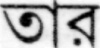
তার
